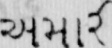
અમારી
